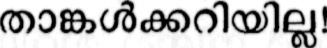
താങ്കള്‍ക്കറിയില്ല!
